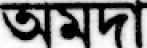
অমদা
